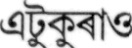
এটুকুৰাও
